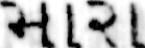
મારા
